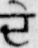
ਦੇ
